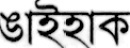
ঙাইহাক
